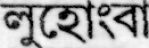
লুহোংবা
